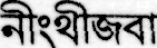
নীংথীজবা
